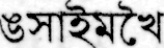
ঙসাইমখৈ
